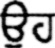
ਉਹ
